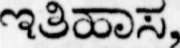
ಇತಿಹಾಸ,
